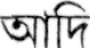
আদি
